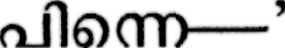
പിന്നെ-’
